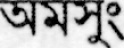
অমসুং
